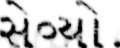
સેવ્યો.
